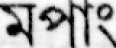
মপাং
